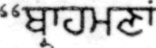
''ਬ੍ਰਾਹਮਣਾਂ
